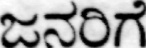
ಜನರಿಗೆ
